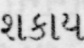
શકાય
